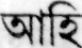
আহি
